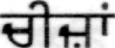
ਚੀਜ਼ਾਂ
